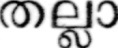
തല്ലാ
